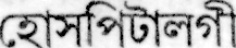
হোসপিটালগী
